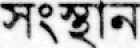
সংস্থান
